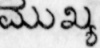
ಮುಖ್ಯ
